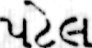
પટેલ
